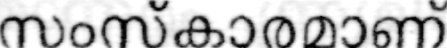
സംസ്കാരമാണ്
